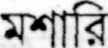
মশারি
